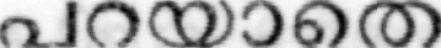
പറയാതെ
